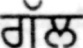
ਗੱਲ
